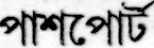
পাশর্পোর্ট
